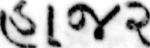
હાજર
